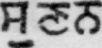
ਸੁਣਨ
